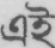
এই
